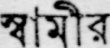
স্বামীর
